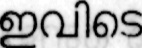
ഇവിടെ
